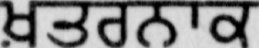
ਖ਼ਤਰਨਾਕ
